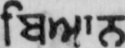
ਬਿਆਨ
